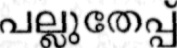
പല്ലുതേപ്പ്
